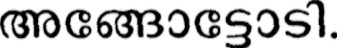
അങ്ങോട്ടോടി.
